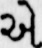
એ
